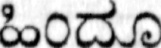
ಹಿಂದೂ
